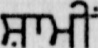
ਸ਼ਾਮੀਂ
